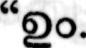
“ഉം.
